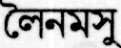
লৈনমসু
